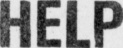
HELP
